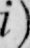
i)
